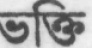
ভক্তি
